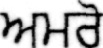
ਅਮਰੋ
